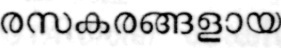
രസകരങ്ങളായ
